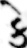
કે
